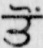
ਤੋਂ
